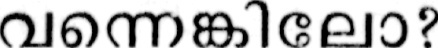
വന്നെങ്കിലോ?
